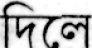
দিলে
